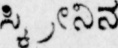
ಸ್ಕ್ರೀನಿನ
